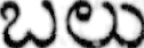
ಬಲು
